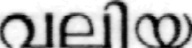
വലിയ
